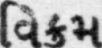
વિક્રમ
